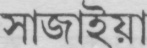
সাজাইয়া
